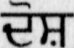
ਦੋਸ਼
